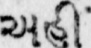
અહીં
